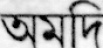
অমদি
